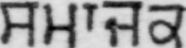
ਸਮਾਜਕ
